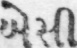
બેસી
